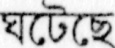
ঘটেছে
